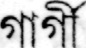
গার্গী
